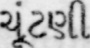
ચૂંટણી
